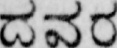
ದವರ
